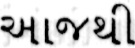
આજથી
